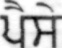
ਪੈਸੇ
